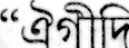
“ঐগীদি
